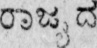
ರಾಜ್ಯದ
